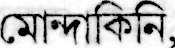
মোন্দাকিনি,
